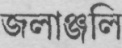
জলাঞ্জলি
